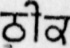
ਠੀਕ
